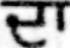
ਦਾ
